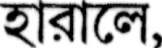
হারালে,
